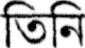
তিনি
